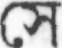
সে
